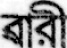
ৱারী
